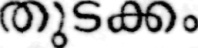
തുടക്കം
